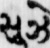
સૂઝે
